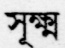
সূক্ষ্ম
